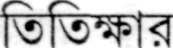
তিতিক্ষার
